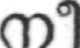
നീ
